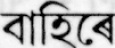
বাহিৰে
